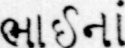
ભાઈનાં
